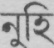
নুহি
